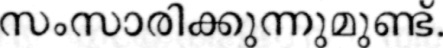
സംസാരിക്കുന്നുമുണ്ട്.
